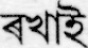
ৰখাই
